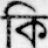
কি
